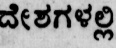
ದೇಶಗಳಲ್ಲಿ
